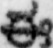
ಈ
